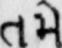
તમે
